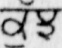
ਕੁੱਝ
